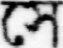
সে
